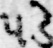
પડે
